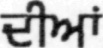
ਦੀਆਂ
